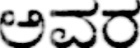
ಅವರ
